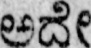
ಅದೇ
